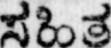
ಸಹಿತ
